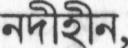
নদীহীন,
